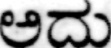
ಅದು
